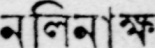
নলিনাক্ষ
